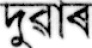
দুৱাৰ
